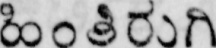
ಹಿಂತಿರುಗಿ
